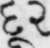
દૂર
